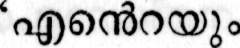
'എന്റെയും
